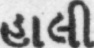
હાલી
